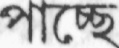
পাচ্ছে
